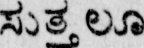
ಸುತ್ತಲೂ
